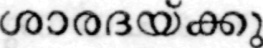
ശാരദയ്ക്കു
